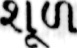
શૂળ
